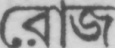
রোজ
